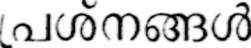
പ്രശ്നങ്ങള്‍
